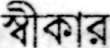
স্বীকার
